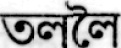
তললৈ
